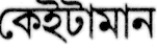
কেইটামান
